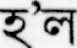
হ'ল
